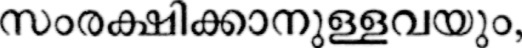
സംരക്ഷിക്കാനുള്ളവയും,
